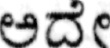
ಅದೇ
